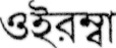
ওইরম্বা
